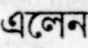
এলেন
